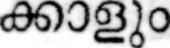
ക്കാളും
